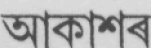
আকাশৰ
